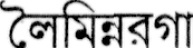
লৈমিন্নরগা
